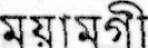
ময়ামগী
